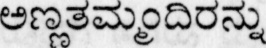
ಅಣ್ಣತಮ್ಮಂದಿರನ್ನು
